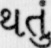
થતું
